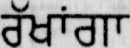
ਰੱਖਾਂਗਾ
